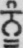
ਨੂੰ
